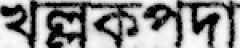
খল্লকপদা
